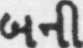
બની
